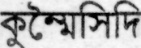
কুম্মৈসিদি
